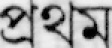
প্ৰথম
